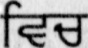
ਵਿਚ
